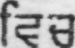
ਵਿਚ
